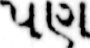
પણ
